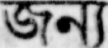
জন্য
